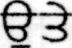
ਉਤੇ
